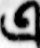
এ
